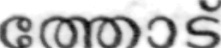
ത്തോട്
